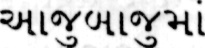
આજુબાજુમાં
